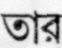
তার
